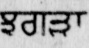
ਝਗੜਾ
